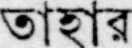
তাহার
